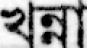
খন্না
